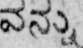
ವನ್ನು
